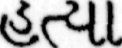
હત્યા
